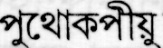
পুথোকপীয়ু
